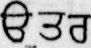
ਉਤਰ
